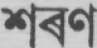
শৰণ
